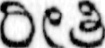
ರೀತಿ
